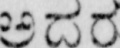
ಅದರ
